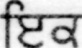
ਇਕ
